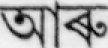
আৰু
